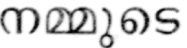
നമ്മുടെ
